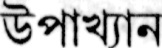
উপাখ্যান
